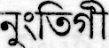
নুংতিগী
